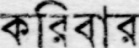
করিবার
